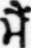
ਮੈਂ
